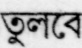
তুলবে
